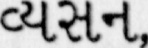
વ્યસન,
